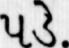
પડે.
